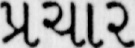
પ્રચાર
